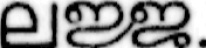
ലജ്ജ.
